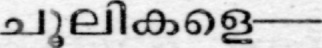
ചൂലികളെ-
